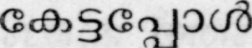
കേട്ടപ്പോള്‍
